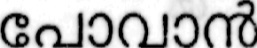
പോവാന്‍
